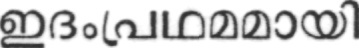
ഇദംപ്രഥമമായി
